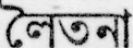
লৈতনা
